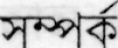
সম্পর্ক
